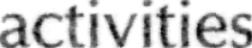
activities
